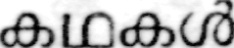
കഥകള്‍
